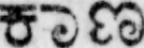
ಕಾಣ
